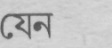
যেন
